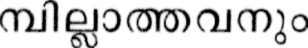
മ്പില്ലാത്തവനും
